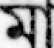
মা
